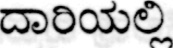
ದಾರಿಯಲ್ಲಿ
